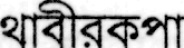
থাবীরকপা
